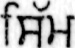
ਸਿੱਮ
